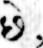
છે,
